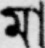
মা
